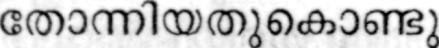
തോന്നിയതുകൊണ്ടു
